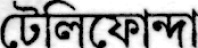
টেলিফোন্দা
